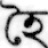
হৈ
